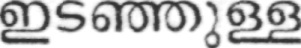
ഇടഞ്ഞുള്ള
